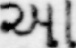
આ
